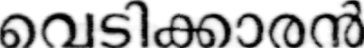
വെടിക്കാരന്‍
